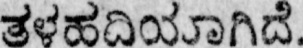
ತಳಹದಿಯಾಗಿದೆ.
